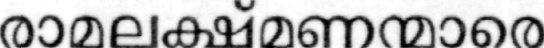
രാമലക്ഷ്മണന്മാരെ
